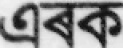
এৰক
